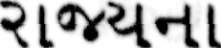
રાજ્યના
